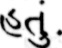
હતું.
